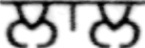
ਲਾਲ
